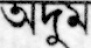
অদুম
